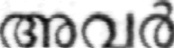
അവര്‍
